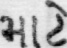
માટે
